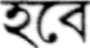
হবে
